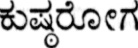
ಕುಷ್ಠರೋಗ
